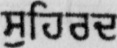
ਸੁਹਿਰਦ
